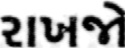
રાખજો
